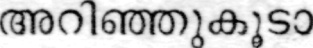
അറിഞ്ഞുകൂടാ
